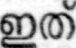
ഇത്
